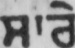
ਸਾਰੇ
